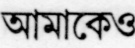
আমাকেও
